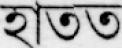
হাতত
